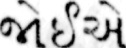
જોઈએ
